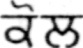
ਕੋਲ
